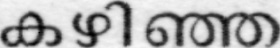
കഴിഞ്ഞ
